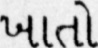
ખાતો
